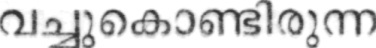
വച്ചുകൊണ്ടിരുന്ന
